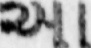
આ
